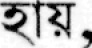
হায়,
